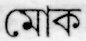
মোক
